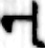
ન
